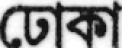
ঢোকা
